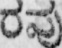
ರವು
